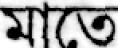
মাতে
